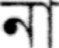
না
